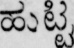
ಹುಟ್ಟಿ
